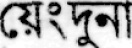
য়েংদুনা
